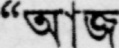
‘‘আজ
